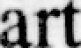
art
